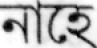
নাহে
